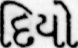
દિયો
